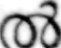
ല്‍
